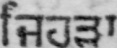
ਜਿਹੜਾ
